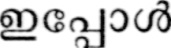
ഇപ്പോള്‍
